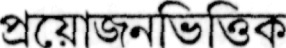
প্রয়োজনভিত্তিক
